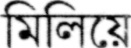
মিলিয়ে
